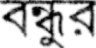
বন্ধুর
